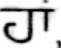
ਹਾਂ,
